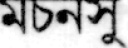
মচনসু
